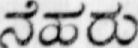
ನೆಹರು
